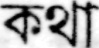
কথা
